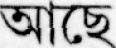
আছে
